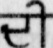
ਦੀ
